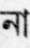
না
